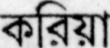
করিয়া
